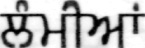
ਲੰਮੀਆਂ
